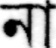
না
